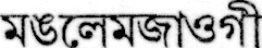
মঙলেমজাওগী
